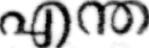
എന്ത
